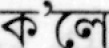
ক'লে
